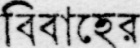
বিবাহের
